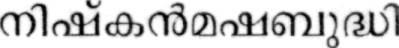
നിഷ്കന്‍മഷബുദ്ധി
